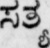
ಸತ್ಯ
